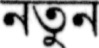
নতুন
